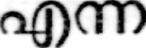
എന്ന
